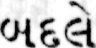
બદલે
